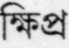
ক্ষিপ্র
